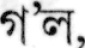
গ'ল,
